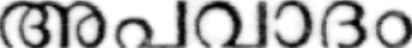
അപവാദം
